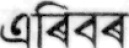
এৰিবৰ
